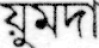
য়ুমদা
